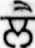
ਲੈ
